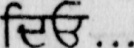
ਦਿਓ...
